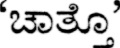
'ಚಾತ್ತೊ'
